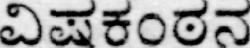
ವಿಷಕಂಠನ
